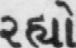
રહ્યો
